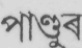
পাণ্ডুৰ
